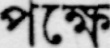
পক্ষে
